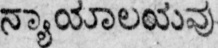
ನ್ಯಾಯಾಲಯವು
